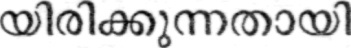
യിരിക്കുന്നതായി
